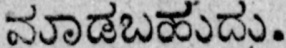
ಮಾಡಬಹುದು.
